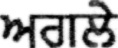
ਅਗਲੇ
